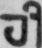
ਹੀ
